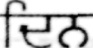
ਦਿਨ
